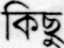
কিছু
